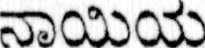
ನಾಯಿಯ
